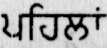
ਪਹਿਲਾਂ
